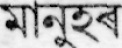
মানুহৰ
